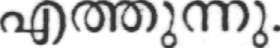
എത്തുന്നു.
